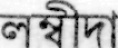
লম্বীদা
